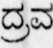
ದ್ರವ
